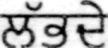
ਲੱਭਦੇ
